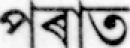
পৰাত
